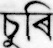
চুৰি
